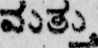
ಮತ್ತು
